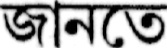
জানতে
